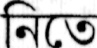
নিতে
